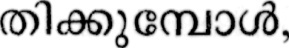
തിക്കുമ്പോള്‍,
